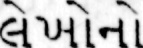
લેખોનો
